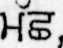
ਮੱਛ,
